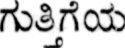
ಗುತ್ತಿಗೆಯ
